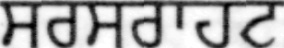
ਸਰਸਰਾਹਟ
